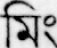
মিং
